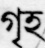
গৃহ
